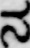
ನ
